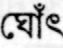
ঘোঁত্
